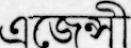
এজেন্সী
